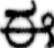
ಈ
